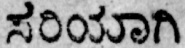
ಸರಿಯಾಗಿ
